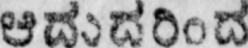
ಆದುದರಿಂದ
